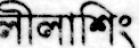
লীলাশিং
